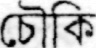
চৌকি
